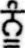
ਨੂੰ
